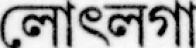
লোৎলগা
